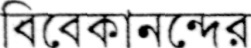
বিবেকানন্দের
